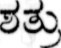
ಶತ್ರು
